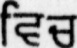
ਵਿਚ
